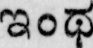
ಇಂಥ
